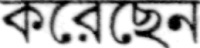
করেছেন
